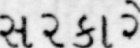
સરકારે
